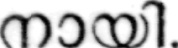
നായി.
